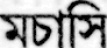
মচাসি
